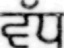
ਵੱਧ
